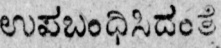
ಉಪಬಂಧಿಸಿದಂತೆ
